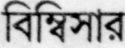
বিম্বিসার
